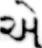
એ
